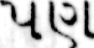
પણ
